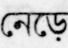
নেড়ে
